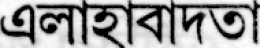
এলাহাবাদতা
